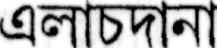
এলাচদানা
